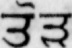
ਤੋੜ
